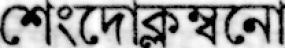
শেংদোক্লম্বনো
